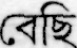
বেছি
